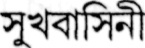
সুখবাসিনী
